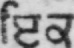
ਇਕ
